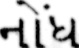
નોંધ
